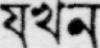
যখন
